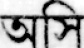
অসি
